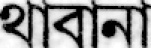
থাবানা
